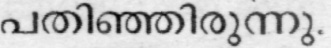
പതിഞ്ഞിരുന്നു.
